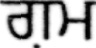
ਗ਼ਮ
